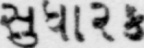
સુધારક
